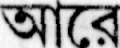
আরে
